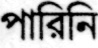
পারিনি
